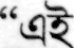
"এই
